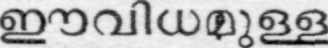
ഈവിധമുള്ള
